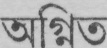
অগ্নিত
